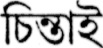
চিন্তাই
